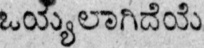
ಒಯ್ಯಲಾಗಿದೆಯೆ
